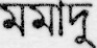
মমাদু
